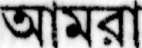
আমরা
